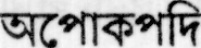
অপোকপদি
